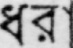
ধরা
